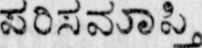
ಪರಿಸಮಾಪ್ತಿ
